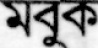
মবুক
